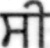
ਸੀ
